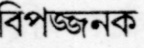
বিপজ্জনক
